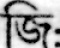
জি:
